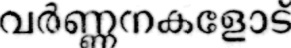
വര്‍ണ്ണനകളോട്
